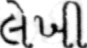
લેખી
